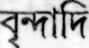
বৃন্দাদি
